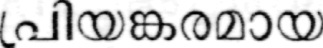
പ്രിയങ്കരമായ
